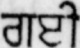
ਗਈ
